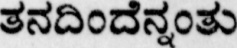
ತನದಿಂದೆನ್ನಂತು
